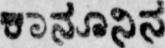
ಕಾನೂನಿನ
